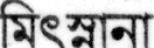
মিৎস্নানা
